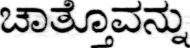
ಚಾತ್ತೊವನ್ನು
